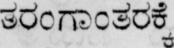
ತರಂಗಾಂತರಕ್ಕೆ
